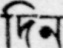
দিন
